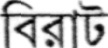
বিরাট
